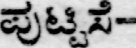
ಪುಟ್ಟಿಸೆ-
